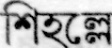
শিহল্লে
